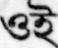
ওই
